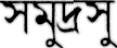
সমুদ্রসু
